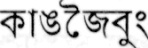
কাঙজৈবুং
